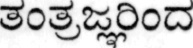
ತಂತ್ರಜ್ಞರಿಂದ
